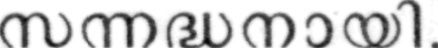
സന്നദ്ധനായി.
